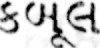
કબૂલ
